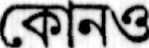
কোনও
